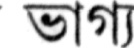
ভাগ্য
